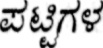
ಪಟ್ಟಿಗಳ
